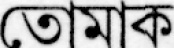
তোমাক
